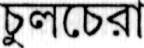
চুলচেরা
